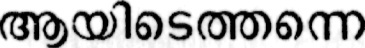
ആയിടെത്തന്നെ
